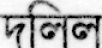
দলিল
